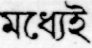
মধ্যেই
